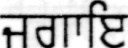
ਜਗਾਇ
